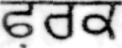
ਫ਼ਰਕ
